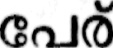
പേര്
